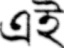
এই
